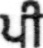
ਪੀ
